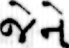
જેને
